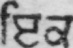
ਇਕ
